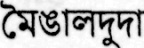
মৈঙালদুদা
